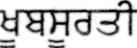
ਖੂਬਸੂਰਤੀ
